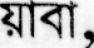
য়াবা,
